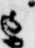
હું
